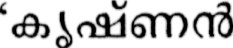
‘കൃഷ്ണന്‍
